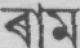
ৰাম
